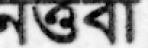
নত্তবা
